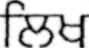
ਲਿਖ
